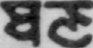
ਬਣ
